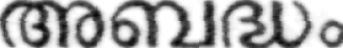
അബദ്ധം
